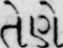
તેણે
